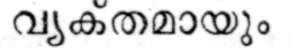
വ്യക്തമായും
